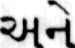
અને
